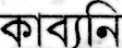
কাব্যনি
